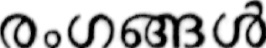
രംഗങ്ങള്‍
